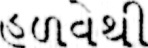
હળવેથી
